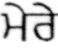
ਮੇਰੇ
